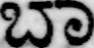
ಬಾ
